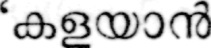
‘കളയാന്‍
